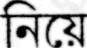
নিয়ে
